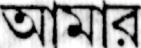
আমার
